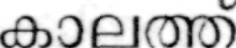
കാലത്ത്
